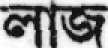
লাজ
